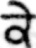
ਕੇ
